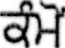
ਕੰਮੋਂ
